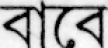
বাবে
